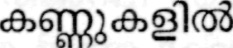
കണ്ണുകളില്‍
